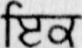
ਇਕ
